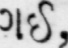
ગઈ,
